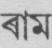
ৰাম
